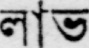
লাভ
